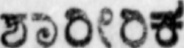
ಶಾರೀರಿಕ
